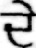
ਦੇ
